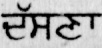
ਦੱਸਣਾ
